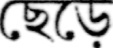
ছেড়ে
